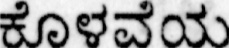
ಕೊಳವೆಯ
